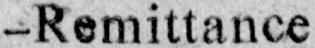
-Remittance
